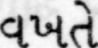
વખતે
